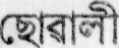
ছোৱালী
